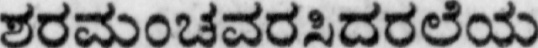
ಶರಮಂಚವರಸಿದರಲೆಯ
